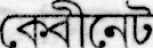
কেবীনেট
